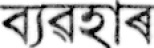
ব্যৱহাৰ
